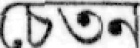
চেতন
